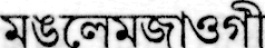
মঙলেমজাওগী
